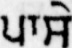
ਪਾਸੇ
